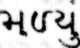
મળ્યું
